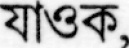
যাওক,
